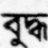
বুদ্ধ
